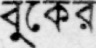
বুকের
